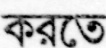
করতে
